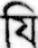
যি
